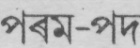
পৰম-পদ
